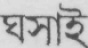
ঘসাই
